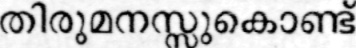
തിരുമനസ്സുകൊണ്ട്
